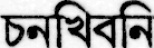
চনখিবনি
